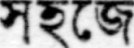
সহজে
